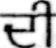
ਦੀ
